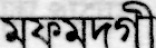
মফমদগী
